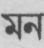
মন
